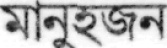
মানুহজন
